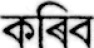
কৰিব
